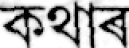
কথাৰ
